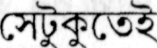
সেটুকুতেই
